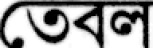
তেবল
